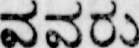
ವವರು
